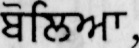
ਬੋਲਿਆ,
